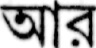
আর
